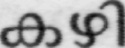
കഴി
